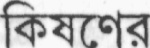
কিষণের
